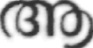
ആ
